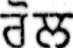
ਰੋਲ
